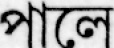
পালে
